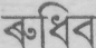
ৰুধিব
